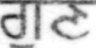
ਗੁਣ
